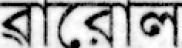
ৱারোল
